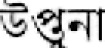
উপ্তুনা
